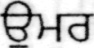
ਉਮਰ
